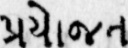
પ્રયોજન
